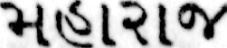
મહારાજ
